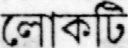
লোকটি
